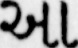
આ
